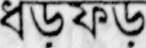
ধড়ফড়
